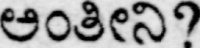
ಅಂತೀನಿ?
